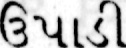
ઉપાડી
